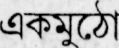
একমুঠো
